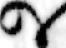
મને
